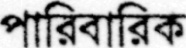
পারিবারিক
